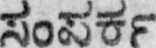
ಸಂಪರ್ಕ
